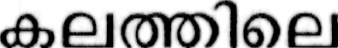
കലത്തിലെ
